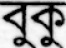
বুকু
